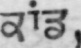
ਕਾਂਡ,
